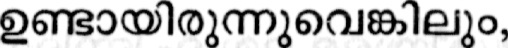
ഉണ്ടായിരുന്നുവെങ്കിലും,
